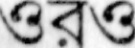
ওরও
